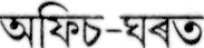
অফিচ-ঘৰত
